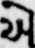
એ
